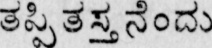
ತಪ್ಪಿತಸ್ತನೆಂದು
